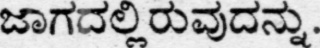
ಜಾಗದಲ್ಲಿರುವುದನ್ನು.
